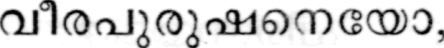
വീരപുരുഷനെയോ,
